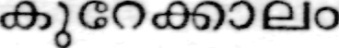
കുറേക്കാലം
